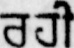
ਰਹੀ
